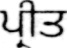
ਪ੍ਰੀਤ
